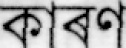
কাৰণ
